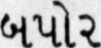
બપોર
